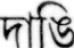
দাঙি
